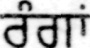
ਰੰਗਾਂ
